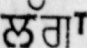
ਲੱਗਾ
